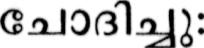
ചോദിച്ചു:
